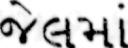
જેલમાં
